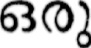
ഒരു
